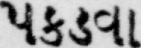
પકડવા
